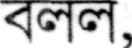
বলল,
